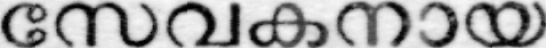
സേവകനായ
